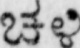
ಚಳಿ
